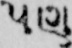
પણ
